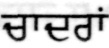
ਚਾਦਰਾਂ
